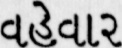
વહેવાર
